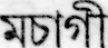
মচাগী
